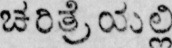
ಚರಿತ್ರೆಯಲ್ಲಿ
